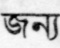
জন্য
